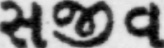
સજીવ
